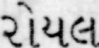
રોયલ
